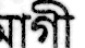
মাগী
